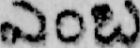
ಎಂಬ
